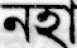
নহা
